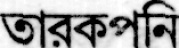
তারকপনি
